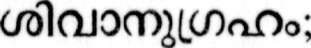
ശിവാനുഗ്രഹം;
